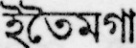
ইতৈমাগা
